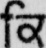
ਕਿ
